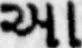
આ
